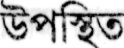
উপস্থিত
